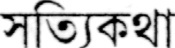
সত্যিকথা
